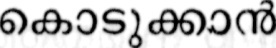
കൊടുക്കാന്‍
